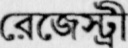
রেজেস্ট্রী
